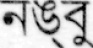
নঙবু
